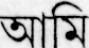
আমি
